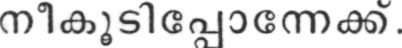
നീകൂടിപ്പോന്നേക്ക്.
